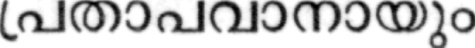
പ്രതാപവാനായും
